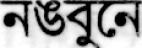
নঙবুনে
